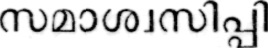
സമാശ്വസിപ്പി
